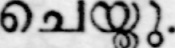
ചെയ്തു.
